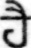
ਹੈ
